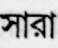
সারা
